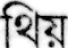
থিয়
